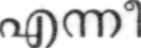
എന്നീ
